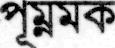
পূম্নমক
